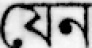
যেন
